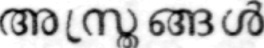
അസ്ത്രങ്ങള്‍
